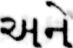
અને
